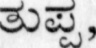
ತುಪ್ಪ,
